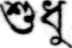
শুধু
